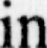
in
